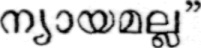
ന്യായമല്ല”
